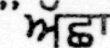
''ਅੱਛਾ
